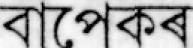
বাপেকৰ
